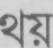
থয়
